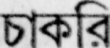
চাকরি
